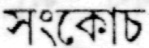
সংকোচ
